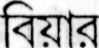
বিয়ার
